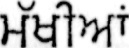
ਮੱਖੀਆਂ
